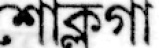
শোক্লগা
